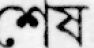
শেষ
